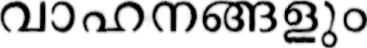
വാഹനങ്ങളും
